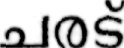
ചരട്
